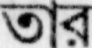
তার
